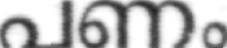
പണം
